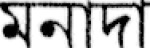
মনাদা
